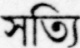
সত্যি
